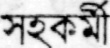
সহকর্মী
